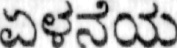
ಏಳನೆಯ
